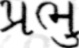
પ્રભુ
